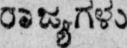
ರಾಜ್ಯಗಳು
